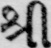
શ્રી
